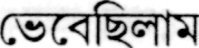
ভেবেছিলাম
